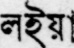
লইয়া
